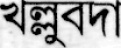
খল্লুবদা
